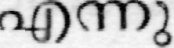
എന്നു
